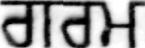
ਗਰਮ
